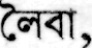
লৈবা,
